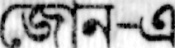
জোন-এ
